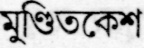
মুণ্ডিতকেশ
